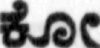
ಕೋ
